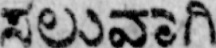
ಸಲುವಾಗಿ
